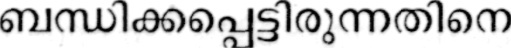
ബന്ധിക്കപ്പെട്ടിരുന്നതിനെ
